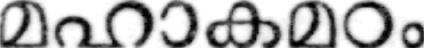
മഹാകമഠം
